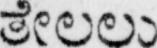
ತೇಲಲು
